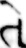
તે
